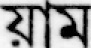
য়াম
